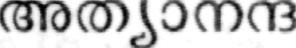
അത്യാനന്ദ
